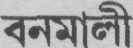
বনমালী
